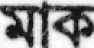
মাক
